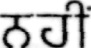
ਨਹੀਂ
